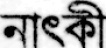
নাৎকী
